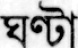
ঘণ্টা
